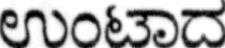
ಉಂಟಾದ
